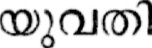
യുവതി
